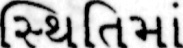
સ્થિતિમાં
